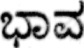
ಭಾವ
